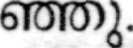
ഞ്ഞു.
